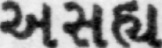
અસહ્ય
